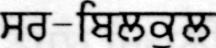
ਸਰ-ਬਿਲਕੁਲ
